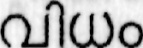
വിധം
